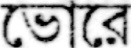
ভোরে
